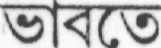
ভাবতে
